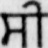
ਸੀ
